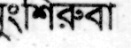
নুংশিরুবা
